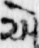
એ
